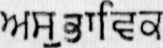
ਅਸੁਭਾਵਿਕ
